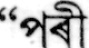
"পৰী
